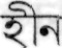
হীন
